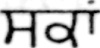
ਸਕਾਂ
